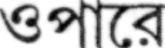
ওপারে
